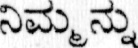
ನಿಮ್ಮನ್ನು
